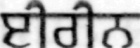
ਈਰੀਨ
